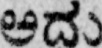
ಅದು
